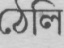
ঠেলি
